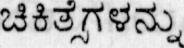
ಚಿಕಿತ್ಸೆಗಳನ್ನು
